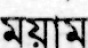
ময়াম
